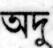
অদু
